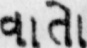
વાતો
